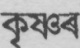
কৃষ্ণৰ
